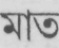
মাত
